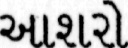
આશરો
